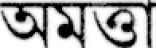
অমত্তা
